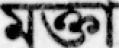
মক্তা
